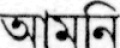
আমনি
